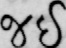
જઈ
